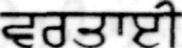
ਵਰਤਾਈ
